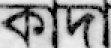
কাদা
